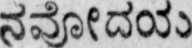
ನವೋದಯ
